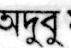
অদুবু
